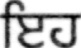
ਇਹ
